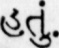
હતું.
